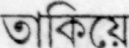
তাকিয়ে
